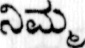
ನಿಮ್ಮ
